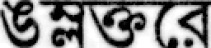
ঙম্লক্তরে
